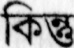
কিন্তু
